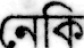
নেকি
